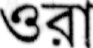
ওরা
